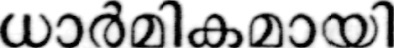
ധാര്‍മികമായി
